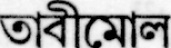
তাবীমোল
